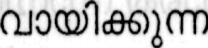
വായിക്കുന്ന
